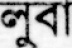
লুবা
